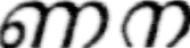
ണന
